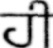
ਹੀ
